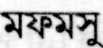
মফমসু
